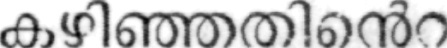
കഴിഞ്ഞതിന്റെ
